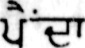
ਪੈਂਦਾ
